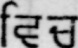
ਵਿਚ
